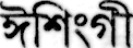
ঈশিংগী
